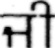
ਜੀ
